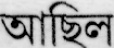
আছিল
